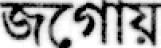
জগোয়
